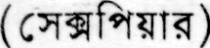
(সেক্সপিয়ার)
